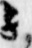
કે,
